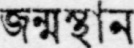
জন্মস্থান
